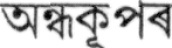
অন্ধকূপৰ
